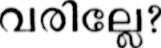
വരില്ലേ?
